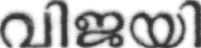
വിജയി
